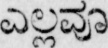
ಎಲ್ಲವೂ
